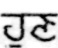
ਹੁਣ
